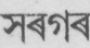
সৰগৰ
